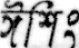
ঈশিং
